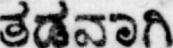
ತಡವಾಗಿ
